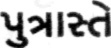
પુત્રાસ્તે
